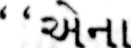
"એના
